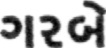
ગરબે
